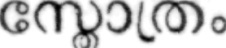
സ്തോത്രം
